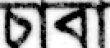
চাবা
